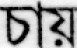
চায়
